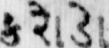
કરોડો
